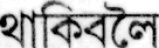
থাকিবলৈ
